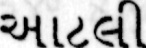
આટલી
